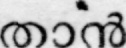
താന്‍
